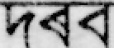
দৰব
